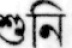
শুনি
